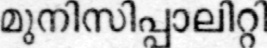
മുനിസിപ്പാലിറ്റി
